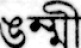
ঙম্মী
